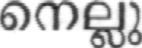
നെല്ലു
